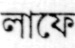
লাফে
